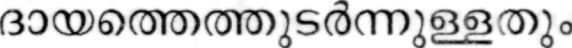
ദായത്തെത്തുടര്‍ന്നുള്ളതും
